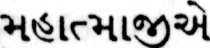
મહાત્માજીએ
